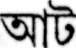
আট
